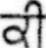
ਕੀ
